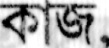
কাজ,
